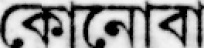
কোনোবা
